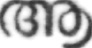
ആ
